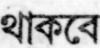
থাকবে
